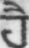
ਹੈ
